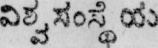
ವಿಶ್ವಸಂಸ್ಥೆಯ
